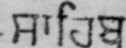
ਸਾਹਿਬ
